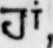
ਹਾਂ,
